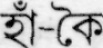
হাঁ-কৈ
